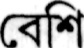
বেশি
